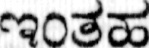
ಇಂತಹ
